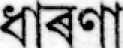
ধাৰণা
